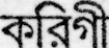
করিগী
